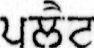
ਪਲੈਟ
